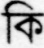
কি
